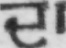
ਦਾ
